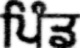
ਪਿੰਡ
